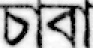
চাবা
